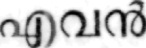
എവന്‍
